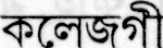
কলেজগী
